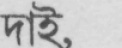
দাই,
